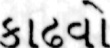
કાઢવો
